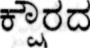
ಕ್ಷೌರದ
